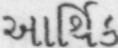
આર્થિક
